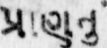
પ્રાણનું
